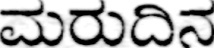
ಮರುದಿನ
